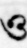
ও
